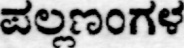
ಪಲ್ಲಣಂಗಳ
